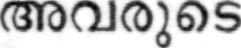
അവരുടെ
